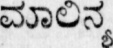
ಮಾಲಿನ್ಯ
